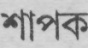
শাপক
